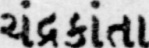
ચંદ્રકાંતા
